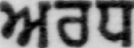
ਅਰਧ
